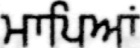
ਮਾਪਿਆਂ
